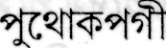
পুথোকপগী
